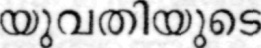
യുവതിയുടെ
